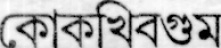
কোকখিবগুম
